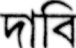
দাবি
